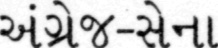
અંગ્રેજ-સેના
